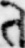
તે
